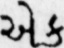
એક
